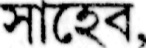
সাহেব,
